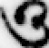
ও
